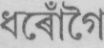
ধৰোঁগৈ
